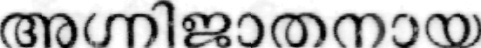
അഗ്നിജാതനായ
